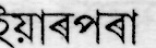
ইয়াৰপৰা
